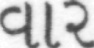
વાર
